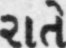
રાતે
